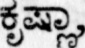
ಕೃಷ್ಣಾ,
